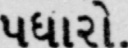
પધારો.
